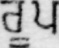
ਰੂਪ
